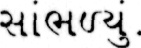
સાંભળ્યું.
